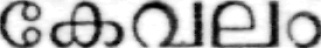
കേവലം
